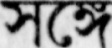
সঙ্গে
